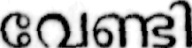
വേണ്ടി
